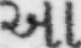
આ
